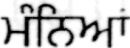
ਮੰਨਿਆਂ
